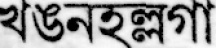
খঙনহল্লগা
